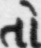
તો
